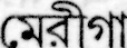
মেরীগা
